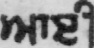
ਆਈ
